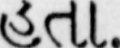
હતા.
